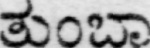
ತು೦ಬಾ
